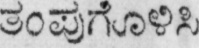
ತಂಪುಗೊಳಿಸಿ
